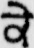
ਕੇ
